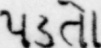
પડતો
